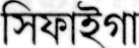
সিফাইগা
